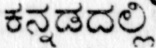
ಕನ್ನಡದಲ್ಲಿ
